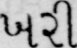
ખરી
